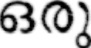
ഒരു
